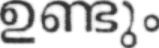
ഉണ്ടും
